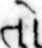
તો
